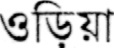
ওড়িয়া
